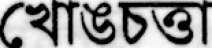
খোঙচত্তা
